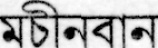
মচীনবান
